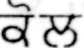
ਕੋਲ
